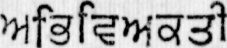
ਅਭਿਵਿਅਕਤੀ
